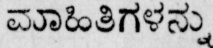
ಮಾಹಿತಿಗಳನ್ನು
